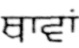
ਥਾਵਾਂ
